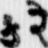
કરે
